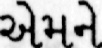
એમને
